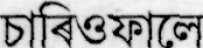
চাৰিওফালে
